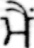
ਮੈਂ
